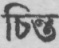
চিন্ত
